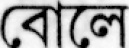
বোলে
